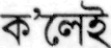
ক'লেই
